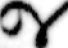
જ
